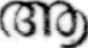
ആ
